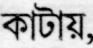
কাটায়,
